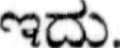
ಇದು.
